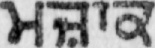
ਮਜ਼ਾਕ
